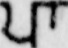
ਪਾ
